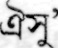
ঐসু’
